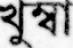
খুম্বা
